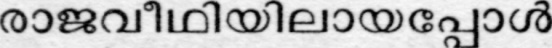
രാജവീഥിയിലായപ്പോള്‍
